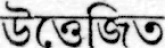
উত্তেজিত
